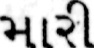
મારી
